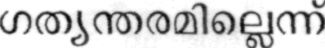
ഗത്യന്തരമില്ലെന്ന്
